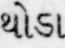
થોડા
